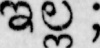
ಇಲ್ಲ;
